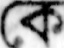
কে
